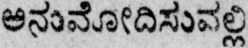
ಅನುಮೋದಿಸುವಲ್ಲಿ
